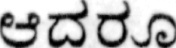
ಆದರೂ
